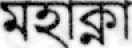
মহাক্না
